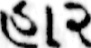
હાર
